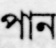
পান
